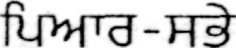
ਪਿਆਰ-ਸਭੇ
